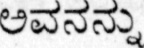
ಅವನನ್ನು
